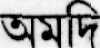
অমদি
